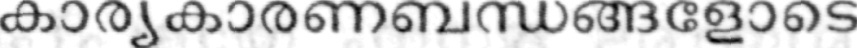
കാര്യകാരണബന്ധങ്ങളോടെ
